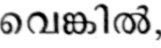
വെങ്കില്‍,
